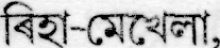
ৰিহা-মেখেলা,
